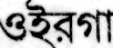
ওইরগা
